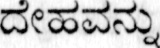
ದೇಹವನ್ನು
